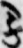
કે
